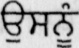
ਉਸਨੂੰ
